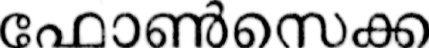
ഫോണ്‍സെക്ക
